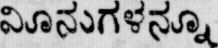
ಮೀನುಗಳನ್ನೂ
